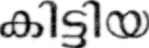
കിട്ടിയ
